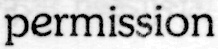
permission
